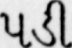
પડી
